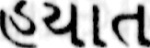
હયાત
